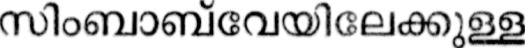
സിംബാബ്വേയിലേക്കുള്ള
